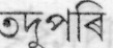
তদুপৰি
